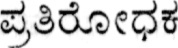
ಪ್ರತಿರೋಧಕ
